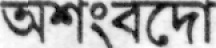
অশংবদো
